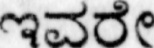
ಇವರೇ
